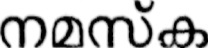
നമസ്ക
